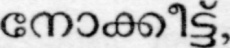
നോക്കീട്ട്,
